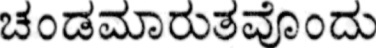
ಚಂಡಮಾರುತವೊಂದು
